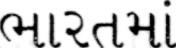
ભારતમાં
